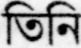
তিনি
